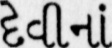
દેવીનાં
